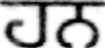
ਹਨ
